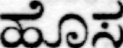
ಹೊಸ
